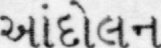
આંદોલન
